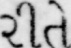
રીતે
